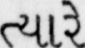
ત્યારે
